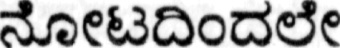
ನೋಟದಿಂದಲೇ
